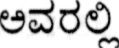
ಅವರಲ್ಲಿ
